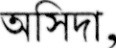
অসিদা,
